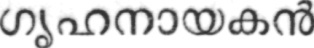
ഗൃഹനായകന്‍
